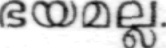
ഭയമല്ല.
